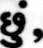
છું,
